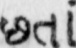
છતાં
